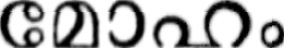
മോഹം
